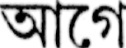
আগে
